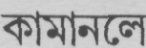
কামানলে
